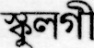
স্কুলগী
